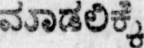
ಮಾಡಲಿಕ್ಕೆ
